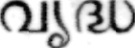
വൃദ്ധ
